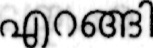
എറങ്ങി
